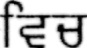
ਵਿਚ
